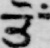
ਤੋਂ
